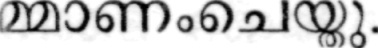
മ്മാണംചെയ്തു.
